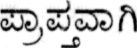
ಪ್ರಾಪ್ತವಾಗಿ
